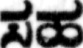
ಸಹ
